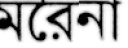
মরৈনা
